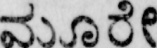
ಮೂರೇ
